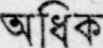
অধিক
